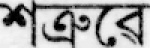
শত্রুৱে
